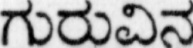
ಗುರುವಿನ
